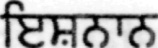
ਇਸ਼ਨਾਨ
